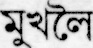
মুখলৈ
